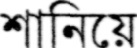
শানিয়ে
